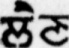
ਲੈਣ
